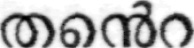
തന്റെ
